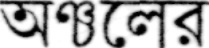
অঞ্চলের
